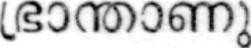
ഭ്രാന്താണു
